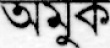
অমুক
